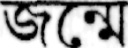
জন্মে
